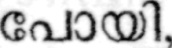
പോയി,
